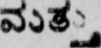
ಮತ್ತು
